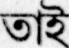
তাই
